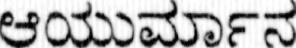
ಆಯುರ್ಮಾನ
